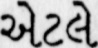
એટલે
